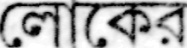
লোকের
